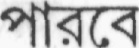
পারবে
